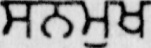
ਸਨਮੁਖ
